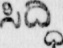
ಸಿದ್ಧಿ
